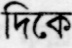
দিকে
